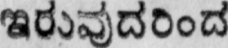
ಇರುವುದರಿಂದ
